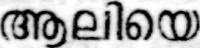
ആലിയെ
